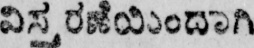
ವಿಸ್ತರಣೆಯಿಂದಾಗಿ
